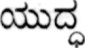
ಯುದ್ಧ
